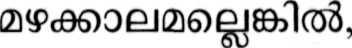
മഴക്കാലമല്ലെങ്കില്‍,
